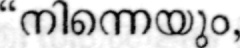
“നിന്നെയും,
